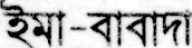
ইমা-বাবাদা
